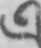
এ
